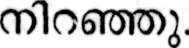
നിറഞ്ഞു.
